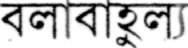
বলাবাহুল্য
